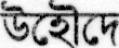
উহৌদে
